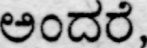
ಅಂದರೆ,
